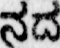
ನದ
